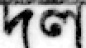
দল
